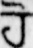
ਹੋ
